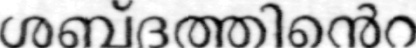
ശബ്ദത്തിന്റെ
